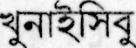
খুনাইসিবু
